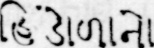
હિંડોળાનો
